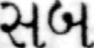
સબ
